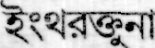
ইংথরক্তুনা
